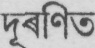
দূৰণিত
